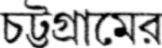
চট্টগ্রামের
